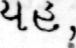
યહ,
